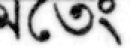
মতেং
